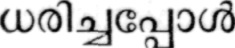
ധരിച്ചപ്പോള്‍
